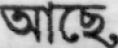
আছে,
